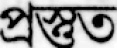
প্রস্তুত
